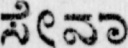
ಸೇವಾ
